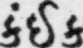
કંઈક
